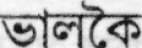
ভালকৈ
